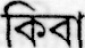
কিবা
